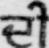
ਦੀ
